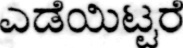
ಎಡೆಯಿಟ್ಟರೆ
